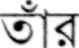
তাঁর
